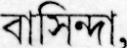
বাসিন্দা,
